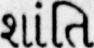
શાંતિ
